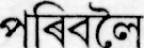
পৰিবলৈ
